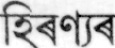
হিৰণ্যৰ
